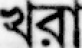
খরা
